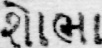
શોભા
